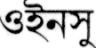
ওইনসু
